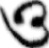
ও
